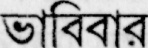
ভাবিবার
